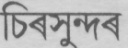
চিৰসুন্দৰ
